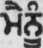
ਮੈਨੂੰ
